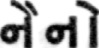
નેનો
